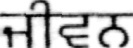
ਜੀਵਨ
